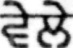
ਵੇਲੇ
